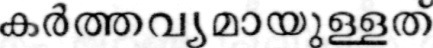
കര്‍ത്തവ്യമായുള്ളത്
